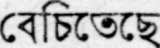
বেচিতেছে
